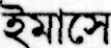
ইমাসে
